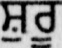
ਸ਼ੁਰੂ
